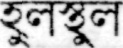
হুলস্থুল
